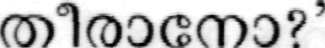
തീരാനോ?’
